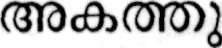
അകത്തു
